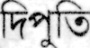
দিপুতি
